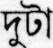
দুটা
